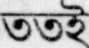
ততই
